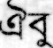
ঐবু
